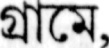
গ্রামে,
